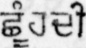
ਛੂੰਹਦੀ
